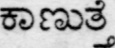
ಕಾಣುತ್ತೆ
